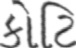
કોટી
